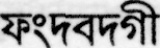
ফংদবগী
